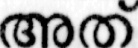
അത്
